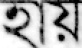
হায়
